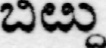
ಬಿೞ್ದು
